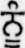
ਨੂੰ
